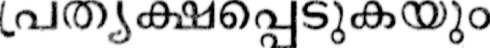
പ്രത്യക്ഷപ്പെടുകയും
